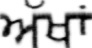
ਅੱਖਾਂ
